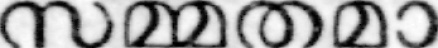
സമ്മതമാ
